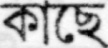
কাছে
